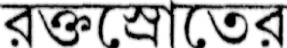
রক্তস্রোতের
